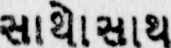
સાથોસાથ
